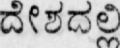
ದೇಶದಲ್ಲಿ
